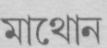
মাথোন
